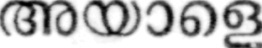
അയാളെ
